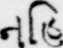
નહિ
